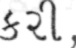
કરી,
